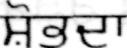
ਸ਼ੋਭਦਾ
